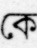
কে
